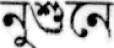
নুশুনে
